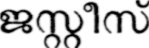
ജസ്റ്റീസ്
